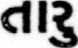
તારુ
